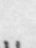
હું
